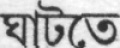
ঘাটতে
